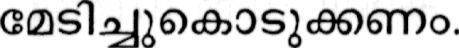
മേടിച്ചുകൊടുക്കണം.
